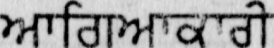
ਆਗਿਆਕਾਰੀ
